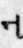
ન
